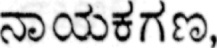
ನಾಯಕಗಣ,
